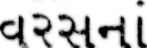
વરસનાં
